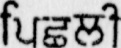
ਪਿਛਲੀ
